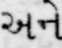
અને
